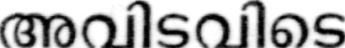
അവിടവിടെ
